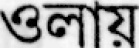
ওলায়
